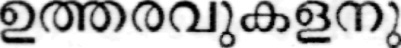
ഉത്തരവുകളനു
